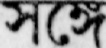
সঙ্গে
